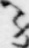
કે
